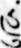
હું
